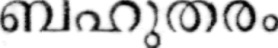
ബഹുതരം
